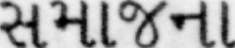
સમાજના
